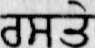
ਰਸਤੇ
